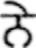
ਨੇ
